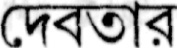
দেবতার
